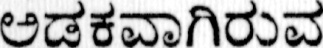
ಅಡಕವಾಗಿರುವ
